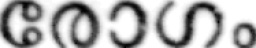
രോഗം
